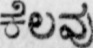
ಕೆಲವು
